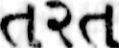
તરત
